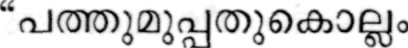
"പത്തുമുപ്പതുകൊല്ലം
